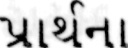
પ્રાર્થના
